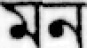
মন
